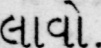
લાવો.
